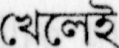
খেলেই
